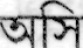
অসি
